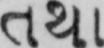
તથા
